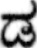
ಡ
